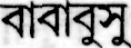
বাবাবুসু
